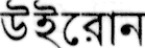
উইরোন
